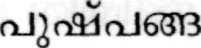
പുഷ്പങ്ങ
